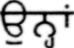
ਉਨ੍ਹਾਂ
